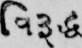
વિરૂદ્ધ
